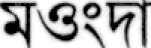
মওংদা
